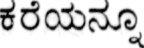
ಕರೆಯನ್ನೂ
